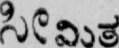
ಸೀಮಿತ
